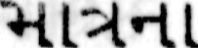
માત્રના
